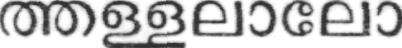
ത്തള്ളലാലോ
